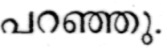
പറഞ്ഞു.
